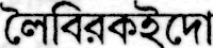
লৈবিরকইদো
